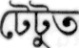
টেটুত
